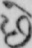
છે
